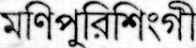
মণিপুরিশিংগী
